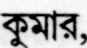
কুমার,
